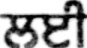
ਲਈ
